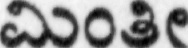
ಮಿಂತೀ
